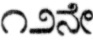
೧೨ನೇ
